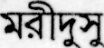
মরীদুসু
